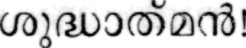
ശുദ്ധാത്മന്‍!
